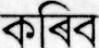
কৰিব
